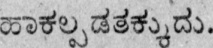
ಹಾಕಲ್ಪಡತಕ್ಕುದು.
